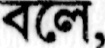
বলে,
